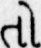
તો
